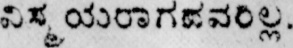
ವಿಸ್ಮಯರಾಗದವರಿಲ್ಲ.
